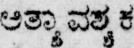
ಅತ್ಯಾವಶ್ಯಕ
